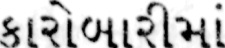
કારોબારીમાં
